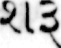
શરૂ
